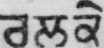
ਰਲਕੇ
